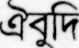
ঐবুদি
